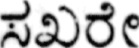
ಸಖರೇ
